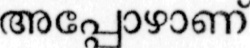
അപ്പോഴാണ്
